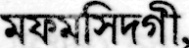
মফমসিদগী,
